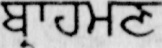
ਬ੍ਰਾਹਮਣ
